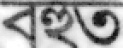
বহুত
